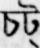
চট্
